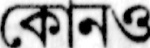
কোনও
